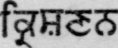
ਕ੍ਰਿਸ਼ਣਨ
